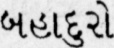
બહાદુરો
